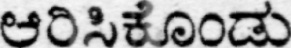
ಆರಿಸಿಕೊಂಡು
